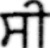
ਸੀ
